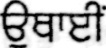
ਉਥਾਈਂ
